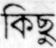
কিছু
